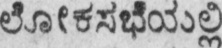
ಲೋಕಸಭೆಯಲ್ಲಿ
